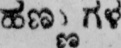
ಹಣ್ಣುಗಳ
